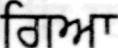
ਗਿਆ
